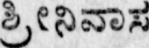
ಶ್ರೀನಿವಾಸ
